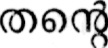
തന്റെ
